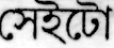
সেইটো
